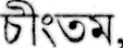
চীংতম,
